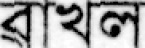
ৱাখল
